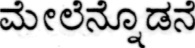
ಮೇಲೆನ್ನೊಡನೆ
